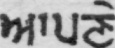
ਆਪਣੇ
